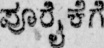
ಪೂರೈಕೆಗೆ
